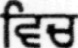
ਵਿਚ
